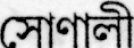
সোণালী
